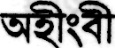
অহীংবী
